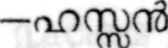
-ഹസ്സന്‍
